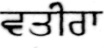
ਵਤੀਰਾ
